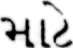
માટે
